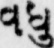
વધુ
